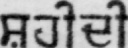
ਸ਼ਹੀਦੀ
